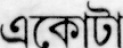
একোটা
